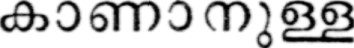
കാണാനുള്ള
